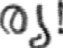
ര്യ!
